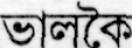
ভালকৈ
